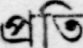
প্রতি
